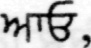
ਆਓ,
